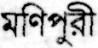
মণিপুরী
